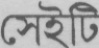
সেইটি
